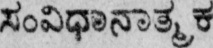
ಸಂವಿಧಾನಾತ್ಮಕ
